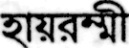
হায়রম্মী
